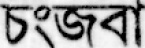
চংজবা
